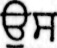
ਉਸ
